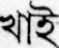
খাই
